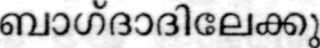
ബാഗ്ദാദിലേക്കു
